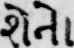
શેનો
